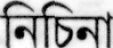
নিচিনা
